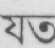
যত
